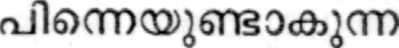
പിന്നെയുണ്ടാകുന്ന
